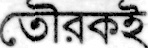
তৌরকই
